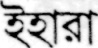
ইহারা
